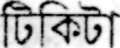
টিকিটা
